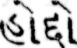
હોદ્દો
